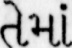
તેમાં
